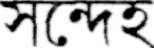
সন্দেহ
